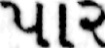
પાર
